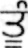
ਤੂੰ
